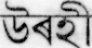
উৰহী
